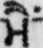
ਮੈਂ
